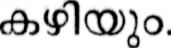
കഴിയും.
